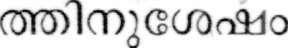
ത്തിനുശേഷം
